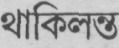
থাকিলন্ত
